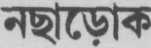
নছাড়োক
